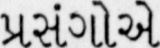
પ્રસેગોએ
